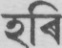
হৰি
